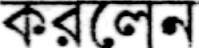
করলেন
